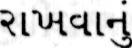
રાખવાનું
